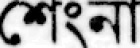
শেংনা
